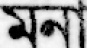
মনা
